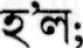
হ'ল;
